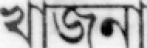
খাজনা
